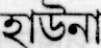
হাউনা
